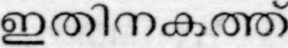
ഇതിനകത്ത്
